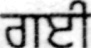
ਗਈ
